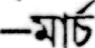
–মার্চ
